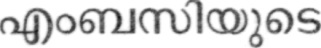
എംബസിയുടെ
